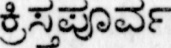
ಕ್ರಿಸ್ತಪೂರ್ವ
